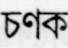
চণক
